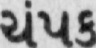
ચંપક
